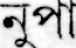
নুপা
